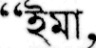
“ইমা,
